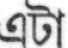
এটা
